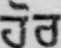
ਹੋਰ
